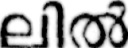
ലില്‍
